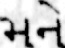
મને
